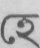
হে
